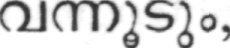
വന്നൂടും,
